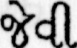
જેવી
